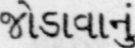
જોડાવાનું
